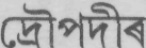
দ্ৰৌপদীৰ
